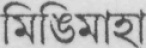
মিঙিমাহা
